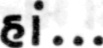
હાં.....
